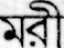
মরী
